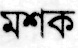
মশক
